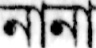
নানা
